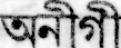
অনীগী
